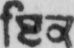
ਇਕ
